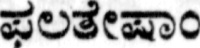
ಫಲತೇಷಾಂ
